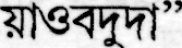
য়াওপদুদা”
